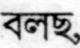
বলছ,
